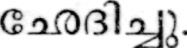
ഛേദിച്ചു.
